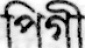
পিগী
